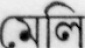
মেলি
